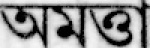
অমত্তা
